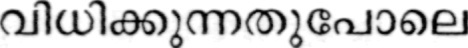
വിധിക്കുന്നതുപോലെ
